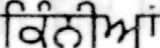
ਕਿੰਨੀਆਂ
